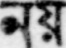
নয়
